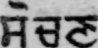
ਸੋਚਣ
